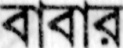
বাবার
